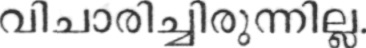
വിചാരിച്ചിരുന്നില്ല.
